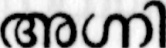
അഗ്നി
